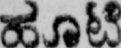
ಹೂಟೆ
